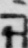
ਜੇ
